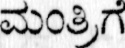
ಮಂತ್ರಿಗೆ
